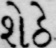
શેઠે
